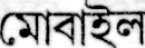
মোবাইল
